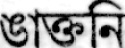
ঙাক্তনি
